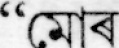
"মোৰ
